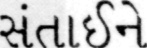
સંતાઈને
